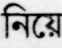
নিয়ে
